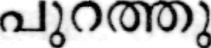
പുറത്തു
